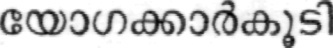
യോഗക്കാര്‍കൂടി
